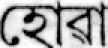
হোৱা
